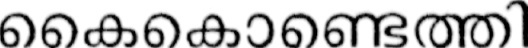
കൈകൊണ്ടെത്തി
